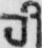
ਹੀ
